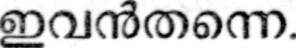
ഇവന്‍തന്നെ.
